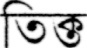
তিক্ত
